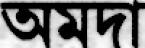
অমদা
